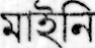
মাইনি
